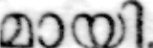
മായി.
